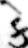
કે
